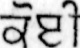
ਕੋਈ
